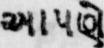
આપણે
